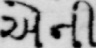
એની
